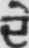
ਦੇ
